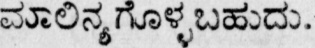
ಮಾಲಿನ್ಯಗೊಳ್ಳಬಹುದು.
